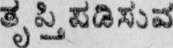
ತೃಪ್ತಿಪಡಿಸುವ
